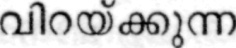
വിറയ്ക്കുന്ന
